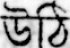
উঠি
